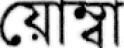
য়োম্বা
